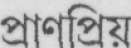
প্ৰাণপ্ৰিয়
